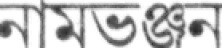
নামভঞ্জন
